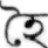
হৈ
